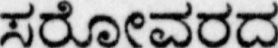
ಸರೋವರದ
